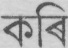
কৰি
